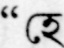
“হে
